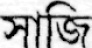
সাজি
